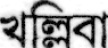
খল্লিবা
